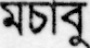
মচাবু
